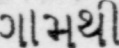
ગામથી
